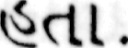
હતા.
